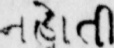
નહોતી
